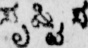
ಸೃಷ್ಟಿಸ
